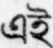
এই
